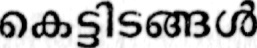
കെട്ടിടങ്ങള്‍
